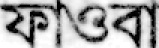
ফাওবা
